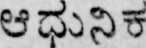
ಆಧುನಿಕ
